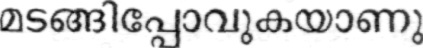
മടങ്ങിപ്പോവുകയാണു
